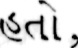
હતો,
